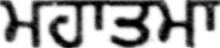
ਮਹਾਤਮਾ
